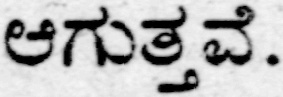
ಆಗುತ್ತವೆ.
